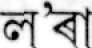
ল'ৰা
